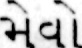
મેવો
